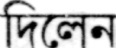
দিলেন
